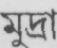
মুদ্ৰা
